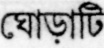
ঘোড়াটি
